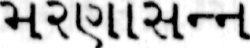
મરણાસન્ન
